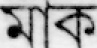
মাক
